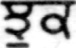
ਝੁਕ
